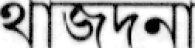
থাজদনা
